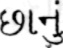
છાનું
